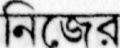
নিজের
